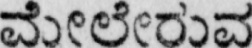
ಮೇಲೇರುವ
